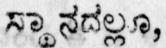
ಸ್ಥಾನದಲ್ಲೂ,
